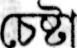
চেষ্টা
